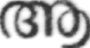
ആ
